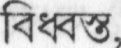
বিধ্বস্ত,
